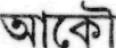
আকৌ
